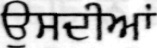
ਉਸਦੀਆਂ
